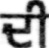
ਦੀ
